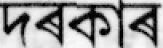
দৰকাৰ
